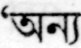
‘অন্য
